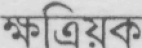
ক্ষত্ৰিয়ক
